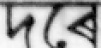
দৰে
